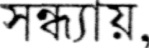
সন্ধ্যায়,
